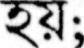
হয়;
